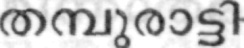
തമ്പുരാട്ടി
